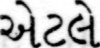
એટલે
